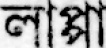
লাপ্পা
